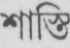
শাস্তি
